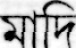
মাদি
